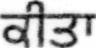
ਕੀਤਾ
